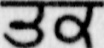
ਤਕ
